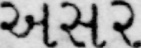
અસર
